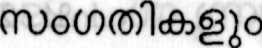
സംഗതികളും
